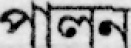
পালন
